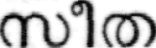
സീത
